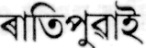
ৰাতিপুৱাই
